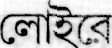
লোইরে
